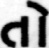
તો
